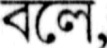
বলে,
